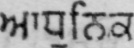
ਆਧੁਨਿਕ
